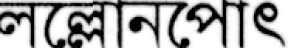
লল্লোনপোৎ
